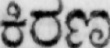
ಕಿರಣ
